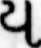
ય
